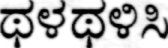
ಥಳಥಳಿಸಿ
